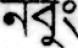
নবুং
